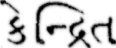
કેન્દ્રિત
